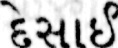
દેસાઈ
